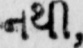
નથી,
